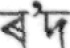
ৰ'দ
